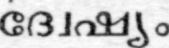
ദ്വേഷ്യം
